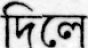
দিলে
